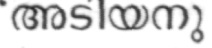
“അടിയനു
